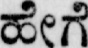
ಹೇಗೆ
